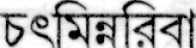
চৎমিন্নরিবা
